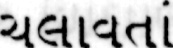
ચલાવતાં
